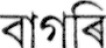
বাগৰি
